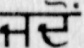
ਜਦੋਂ
